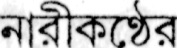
নারীকণ্ঠের
